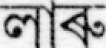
লাৰু
